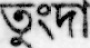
তুংদা
